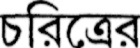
চরিত্রের
